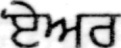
'ਏਅਰ
